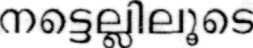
നട്ടെല്ലിലൂടെ
